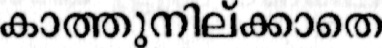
കാത്തുനില്ക്കാതെ
